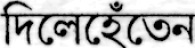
দিলেহেঁতেন
